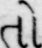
તો
